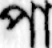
পা
